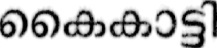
കൈകാട്ടി
